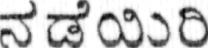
ನಡೆಯಿರಿ
